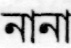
নানা
